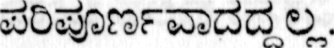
ಪರಿಪೂರ್ಣವಾದದ್ದಲ್ಲ.
